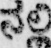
ನಲ್ಲಿ
